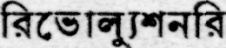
রিভোল্যুশনরি
